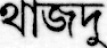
থাজদু
